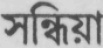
সন্ধিয়া
